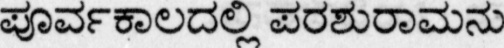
ಪೂರ್ವಕಾಲದಲ್ಲಿಪರಶುರಾಮನು
